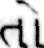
તો
